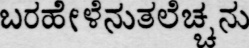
ಬರಹೇಳೆನುತಲೆಚ್ಚನು
